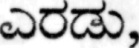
ಎರಡು,
